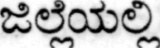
ಜಿಲ್ಲೆಯಲ್ಲಿ
